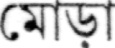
মোড়া
